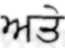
ਅਤੇ
